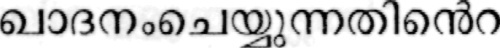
ഖാദനംചെയ്യുന്നതിന്റെ
